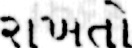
રાખતો
